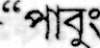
“পাবুং
